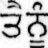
ਤੈਨੂੰ
